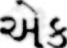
એક
